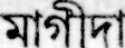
মাগীদা
